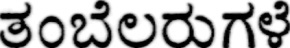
ತಂಬೆಲರುಗಳೆ
